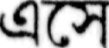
এসে
